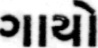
ગાયો
